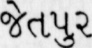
જેતપુર
